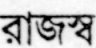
রাজস্ব
